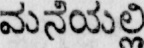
ಮನೆಯಲ್ಲಿ
